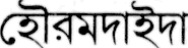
হৌরমদাইদা
